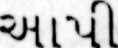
આપી
